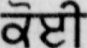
ਕੋਈ
